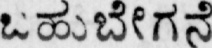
ಬಹುಬೇಗನೆ
